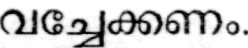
വച്ചേക്കണം.
